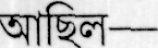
আছিল-
